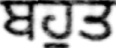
ਬਹੁਤ
